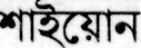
শাইয়োন
